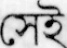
সেই
